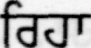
ਰਿਹਾ
